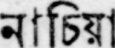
নাচিয়া
